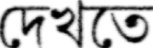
দেখতে
